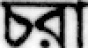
চরা
